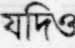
যদিও
